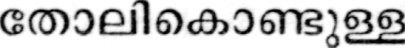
തോലികൊണ്ടുള്ള
